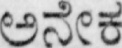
ಅನೇಕ
